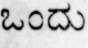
ಒಂದು
